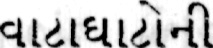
વાટાઘાટોની
